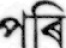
পৰি
